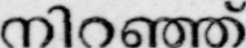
നിറഞ്ഞ്
